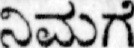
ನಿಮಗೆ
